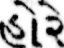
હોરે
